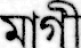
মাগী
